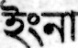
ইংনা
